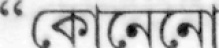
"কোনেনো
